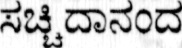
ಸಚ್ಚಿದಾನಂದ
